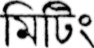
মিটিং
